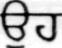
ਉਹ
